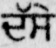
ਦੱਸੇ
